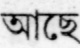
আছে
